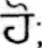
ਹੋ;
